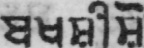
ਬਖਸ਼ੀਸ਼ੋ
